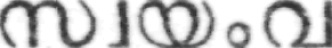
സ്വയംവ
